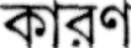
কারণ
